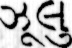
ઝૂલૂ
